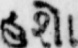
હશો
